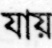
যায়
